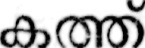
കത്ത്
